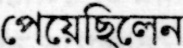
পেয়েছিলেন
